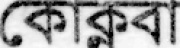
কোক্নবা
